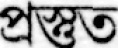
প্রস্তুত
